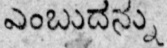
ಎಂಬುದನ್ನು
